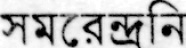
সমরেন্দ্রনি
